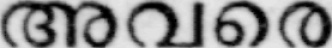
അവരെ
